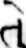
તે
